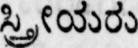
ಸ್ತ್ರೀಯರು
